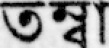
তম্বা
